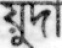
য়ুদা
